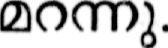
മറന്നു.
